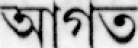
আগত
